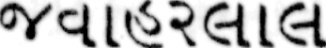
જવાહરલાલ
